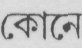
কোনে
